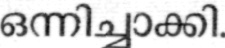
ഒന്നിച്ചാക്കി.
